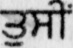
ਤੁਸੀਂ
